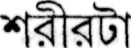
শরীরটা
